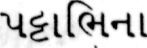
પટ્ટાભિના
